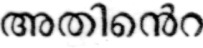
അതിന്റെ
